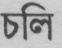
চলি
